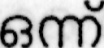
ഒന്ന്
